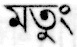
মতুং
